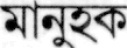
মানুহক
